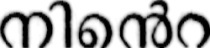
നിന്റെ
